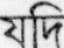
যদি
